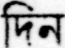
দিন
